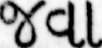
જવા
